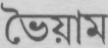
ভৈয়াম
